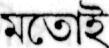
মতোই
